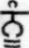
ਨੂੰ
